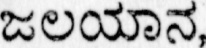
ಜಲಯಾನ,
